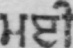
ਮਈ
